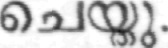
ചെയ്തു.
